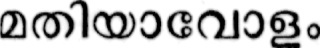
മതിയാവോളം
